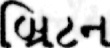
બ્રિટન
